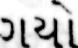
ગયો
